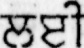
ਲਈ
